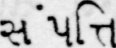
સંપત્તિ
